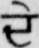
ਦੇ
